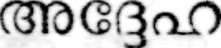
അദ്ദേഹ
